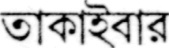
তাকাইবার
